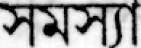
সমস্যা
